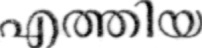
എത്തിയ
